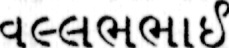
વલ્લભભાઈ
